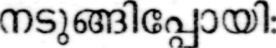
നടുങ്ങിപ്പോയി:
